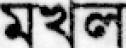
মখল
